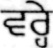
ਵਰ੍ਹੇ
